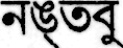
নঙ্তবু
